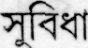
সুবিধা
